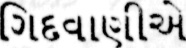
ગિદવાણીએ
